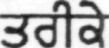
ਤਰੀਕੇ
